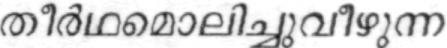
തീര്‍ഥമൊലിച്ചുവീഴുന്ന
